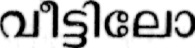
വീട്ടിലോ
